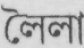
লৈলা
